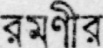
রমণীর
